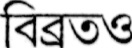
বিব্রতও
